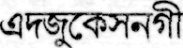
এদজুকেসনগী
